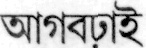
আগবঢ়াই
